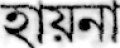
হায়না
